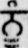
ਨੂੰ
